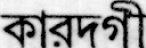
কারদগী
